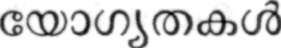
യോഗ്യതകള്‍
